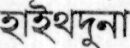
হাইথদুনা
